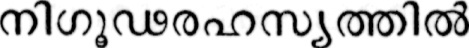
നിഗൂഢരഹസ്യത്തില്‍
